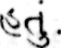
હતું.
